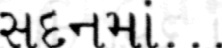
સદનમાં...
